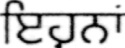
ਇਹਨਾਂ
